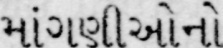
માંગણીઓનો
